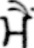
ਮੈਂ
